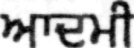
ਆਦਮੀ
